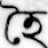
হৈ
